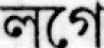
লগে
